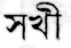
সখী
